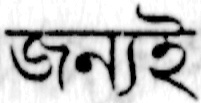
জন্যই
